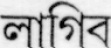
লাগিব
